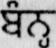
ਬੰਨ੍ਹ
